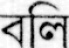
বলি
